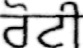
ਰੋਟੀ
